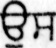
ਉਸ
